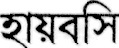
হায়বসি
